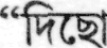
"দিছো
